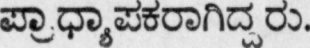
ಪ್ರಾಧ್ಯಾಪಕರಾಗಿದ್ದರು.
